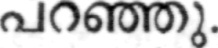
പറഞ്ഞു.
